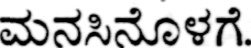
ಮನಸಿನೊಳಗೆ.
